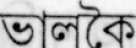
ভালকৈ
